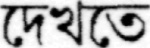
দেখতে
